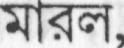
মারল,
